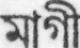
মাগী
